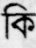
কি
